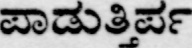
ಪಾಡುತ್ತಿರ್ಪ
